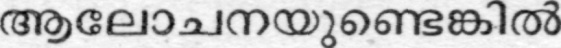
ആലോചനയുണ്ടെങ്കില്‍
